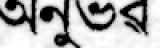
অনুভৱ
